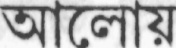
আলোয়
